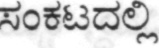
ಸಂಕಟದಲ್ಲಿ
